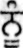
ਨੂੰ
